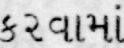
કરવામાં
